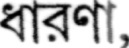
ধারণা,
